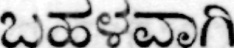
ಬಹಳವಾಗಿ
